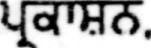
ਪ੍ਰਕਾਸ਼ਨ,
